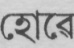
হোৱে
